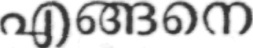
എങ്ങനെ
